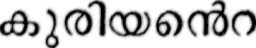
കുരിയന്റെ
